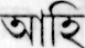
আহি
